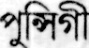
পুন্সিগী
